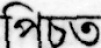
পিচত
